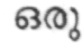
ഒരു
